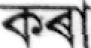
কৰা
